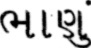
ભાણું
